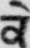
ਕੇ
